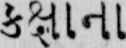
કક્ષાના
